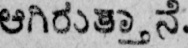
ಆಗಿರುತ್ತಾನೆ.
